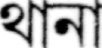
থানা
